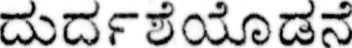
ದುರ್ದಶೆಯೊಡನೆ
